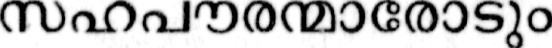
സഹപൌരന്മാരോടും
